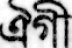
ঐগী
